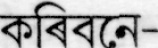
কৰিবনে-
